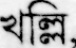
খল্লি,
